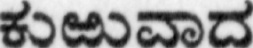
ಕುಱುವಾದ
